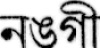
নঙগী
